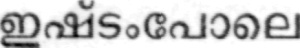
ഇഷ്ടംപോലെ
